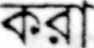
করা
